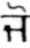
ਜੋ
